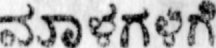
ಮಾಳಗಳಿಗೆ
